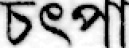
চৎপা
